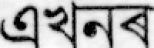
এখনৰ
